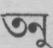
তনু
